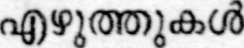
എഴുത്തുകള്‍
